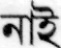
নাই
